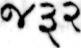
જરૂર
